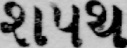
શપથ
